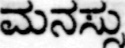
ಮನಸ್ಸು
